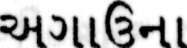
અગાઉના
